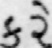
કરે
